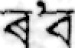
ৰ'ব
